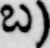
ಬ)
